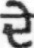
ਦੇ
